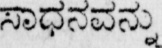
ಸಾಧನವನ್ನು
